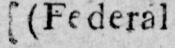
(Federal
